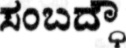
ಸಂಬದ್ದೌ
